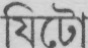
যিটো
